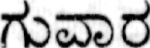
ಗುವಾರ
